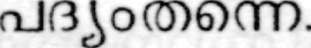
പദ്യംതന്നെ.
